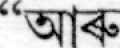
"আৰু
